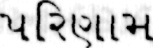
પરિણામ
